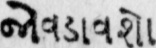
જોવડાવશો
